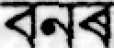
বনৰ
